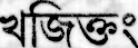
খজিক্তং
